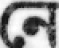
নে
